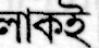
লাকই
